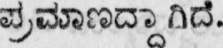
ಪ್ರಮಾಣದ್ದಾಗಿದೆ.
